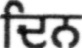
ਦਿਨ
